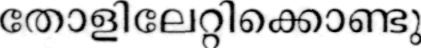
തോളിലേറ്റിക്കൊണ്ടു
